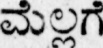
ಮೆಲ್ಲಗೆ
